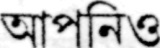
আপনিও
